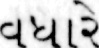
વધારે
